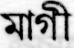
মাগী
